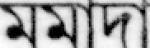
মমাদা
